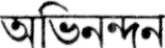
অভিনন্দন
